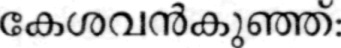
കേശവന്‍കുഞ്ഞ്:
